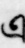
এ
